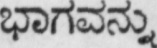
ಭಾಗವನ್ನು
